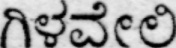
ಗಿಳವೇಲಿ
